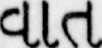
વાત
